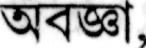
অবজ্ঞা,
